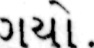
ગયો.
